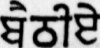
ਬੈਠੀਏ
